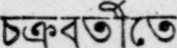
চক্রবর্তীতে
